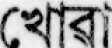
খোৱা
